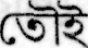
তৌই
